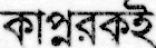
কাপ্নরকই
